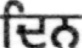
ਦਿਨ
